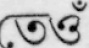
তেওঁ
